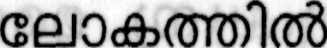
ലോകത്തില്‍
